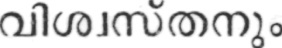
വിശ്വസ്തനും
